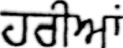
ਹਰੀਆਂ
